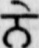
ਨੇ
